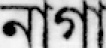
নাগা
